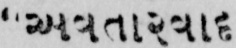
“અવતારવાદ
